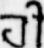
ਹੀ
